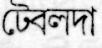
টেবলদা
